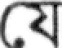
যে
